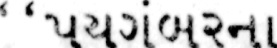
"પયગંબરના
